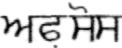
ਅਫ਼ਸੋਸ
